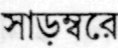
সাড়ম্বরে
